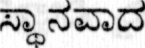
ಸ್ಥಾನವಾದ
